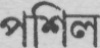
পশিল
